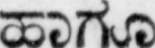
ಹಾಗೂ
